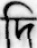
দি
